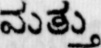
ಮತ್ತು
